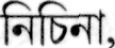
নিচিনা,
